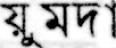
য়ুমদা
